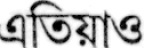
এতিয়াও
